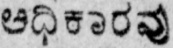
ಅಧಿಕಾರವು
